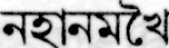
নহানমখৈ
